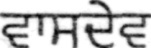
ਵਾਸਦੇਵ
